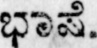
ಭಾಷೆ.
